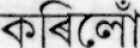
কৰিলোঁ
